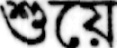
শুয়ে
